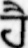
ਹੈ
